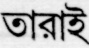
তারাই
